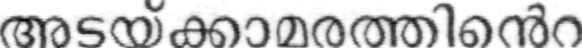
അടയ്ക്കാമരത്തിന്റെ
